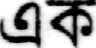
এক
